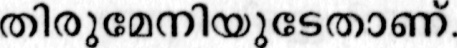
തിരുമേനിയുടേതാണ്.
